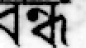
বন্ধ
